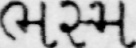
ભસ્મ
